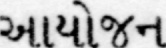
આયોજન
